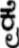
ಕೈ
